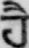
ਹੈ
